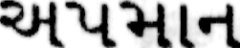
અપમાન
